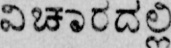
ವಿಚಾರದಲ್ಲಿ
